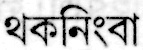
থকনিংবা
